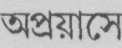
অপ্ৰয়াসে
